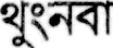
থুংনবা
